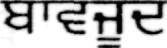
ਬਾਵਜੂਦ
